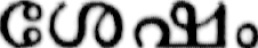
ശേഷം
